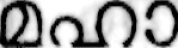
മഹാ
